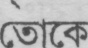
তোকে
